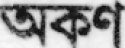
অকণ
